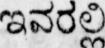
ಇವರಲ್ಲಿ
